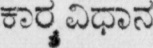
ಕಾರ್‍ಯವಿಧಾನ
